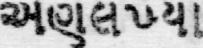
અણલખ્યા
